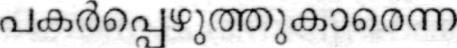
പകര്‍പ്പെഴുത്തുകാരെന്ന
